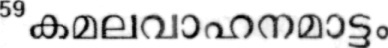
59കമലവാഹനമാട്ടം
